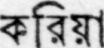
করিয়া
